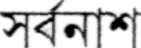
সর্বনাশ
